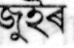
জুইৰ
